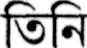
তিনি
